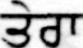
ਤੇਰਾ
